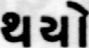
થયો
